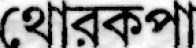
থোরকপা
